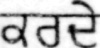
ਕਰਦੇ
